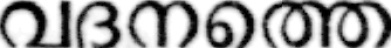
വദനത്തെ
